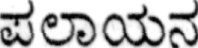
ಪಲಾಯನ
